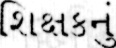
શિક્ષકનું
